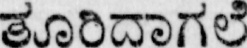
ತೂರಿದಾಗಲೆ
